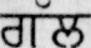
ਗੱਲ
